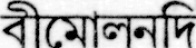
বীমোলনদি
